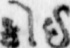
કોઈ
